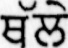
ਥੱਲੇ
